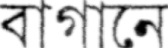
বাগানে
